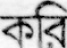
করি
